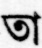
তা
